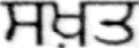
ਸਖ਼ਤ
